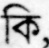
কি,
